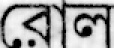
রোল
